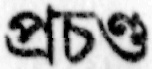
প্রচন্ড
